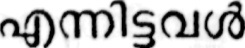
എന്നിട്ടവള്‍
